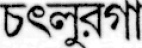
চৎলুরগা
